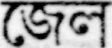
জেল
